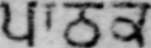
ਪਾਠਕ
